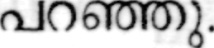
പറഞ്ഞു.
